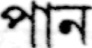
পান
